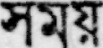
সময়
